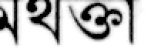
মথক্তা
